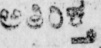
ಅತಿರಿಕ್ತ
